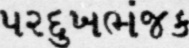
પરદુખભંજક
